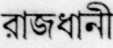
রাজধানী
